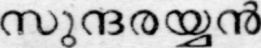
സുന്ദരയ്യന്‍
